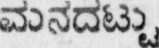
ಮನದಟ್ಟು
